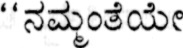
"ನಮ್ಮಂತೆಯೇ
